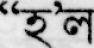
"হ'ল
